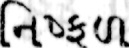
નિષ્ફળ
